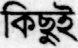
কিছুই
